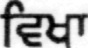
ਵਿਖਾ
